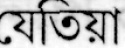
যেতিয়া
